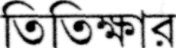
তিতিক্ষার
